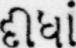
દીધાં
